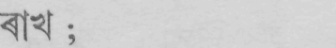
ৰাখ;
